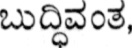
ಬುದ್ಧಿವಂತ,
